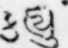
કહ્યું
